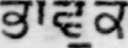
ਭਾਵੁਕ
